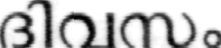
ദിവസം
